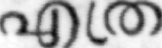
എത്ര
